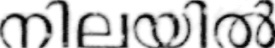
നിലയില്‍
